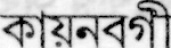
কায়নবগী
